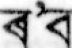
ৰ'ব
